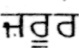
ਜ਼ਰੂਰ
